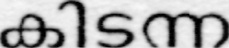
കിടന്ന
